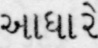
આધારે
